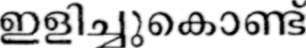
ഇളിച്ചുകൊണ്ട്
